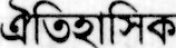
ঐতিহাসিক
